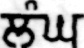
ਲੰਘ
